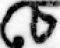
চে
